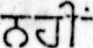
ਨਹੀਂ
